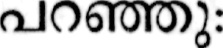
പറഞ്ഞു:
